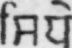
ਸਿਧੇ
